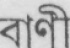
বাণী
